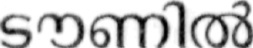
ടൌണില്‍
